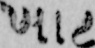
ખાટ
